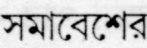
সমাবেশের
